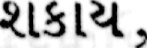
શકાય,
